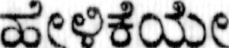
ಹೇಳಿಕೆಯೇ
